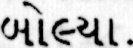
બોલ્યા.
